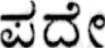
ಪದೇ
